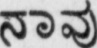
ನಾವು
